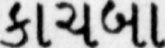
કાચબા
